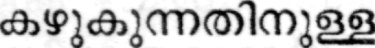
കഴുകുന്നതിനുള്ള
